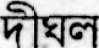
দীঘল
